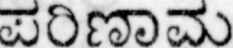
ಪರಿಣಾಮ
